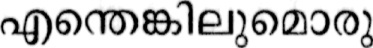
എന്തെങ്കിലുമൊരു
